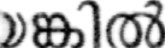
യെങ്കില്‍
